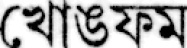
খোঙফম
